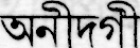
অনীদগী
